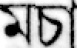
মচা
